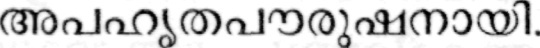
അപഹൃതപൌരുഷനായി.
